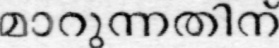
മാറുന്നതിന്
